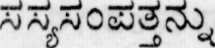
ಸಸ್ಯಸಂಪತ್ತನ್ನು
